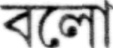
বলো
